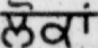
ਲੋਕਾਂ
